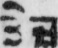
ਤੇਜ਼
